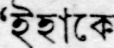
‘ইহাকে
